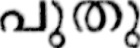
പുതു
